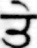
ਤੇ
